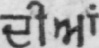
ਦੀਆਂ
